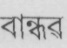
বান্ধৱ
